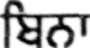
ਬਿਨਾ
